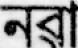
নৱা
